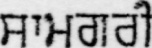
ਸਾਮਗਰੀ
